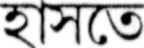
হাসতে
